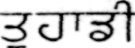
ਤੁਹਾਡੀ
